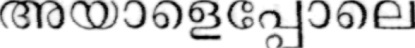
അയാളെപ്പോലെ
